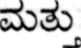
ಮತ್ತು
